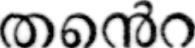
തന്റെ
